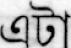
এটা
